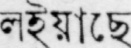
লইয়াছে
